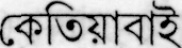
কেতিয়াবাই
